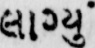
લાગ્યું
